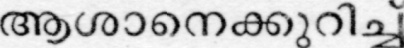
ആശാനെക്കുറിച്ച്
